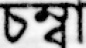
চম্বা
